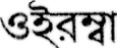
ওইরম্বা
